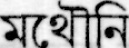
মথৌনি
